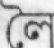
লৈ
